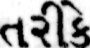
તરીકે
